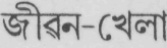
জীৱন-খেলা
